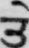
ਤੇ
